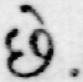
છે.
